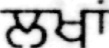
ਲਖਾਂ
